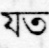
যত
